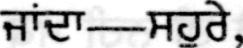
ਜਾਂਦਾ-ਸਹੁਰੇ,
